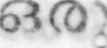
ഒരു
